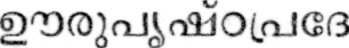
ഊരുപൃഷ്ഠപ്രദേ
